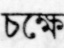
চক্ষে
